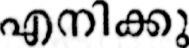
എനിക്കു
